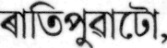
ৰাতিপুৱাটো,
